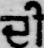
ਦੀ
